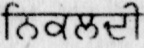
ਨਿਕਲਦੀ
